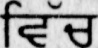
ਵਿੱਚ
